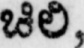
ಚಿಲಿ,
